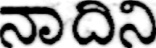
ನಾದಿನಿ
